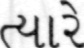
ત્યારે
